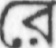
রে
